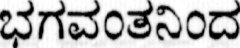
ಭಗವಂತನಿಂದ
